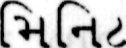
મિનિટ
